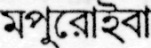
মপুরোইবা
